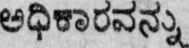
ಅಧಿಕಾರವನ್ನು
